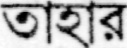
তাহার
